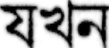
যখন
